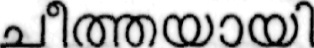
ചീത്തയായി
